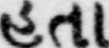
હતા
